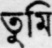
তুমি
